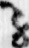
કે
